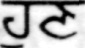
ਹੁਣ
